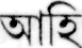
আহি
